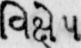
વિક્ષેપ
